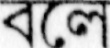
বলে
